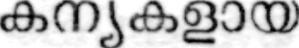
കന്യകളായ
